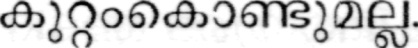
കുറ്റംകൊണ്ടുമല്ല.
